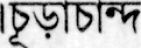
চূড়াচান্দ
